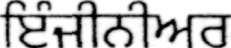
ਇੰਜੀਨੀਅਰ
